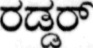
ರಡ್ಡರ್
